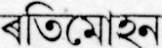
ৰতিমোহন
